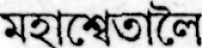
মহাশ্বেতালৈ
